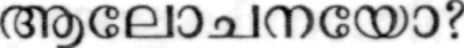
ആലോചനയോ?
